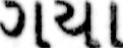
ગયા
